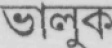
ভালুক
